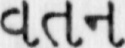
વતન
